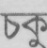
চকু
